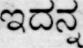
ಇದನ್ನ
